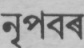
নৃপবৰ
